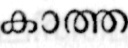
കാത്ത
